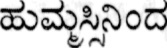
ಹುಮ್ಮಸ್ಸಿನಿಂದ
